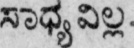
ಸಾಧ್ಯವಿಲ್ಲ.
